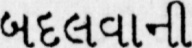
બદલવાની
